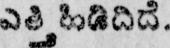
ಎತ್ತಿಹಿಡಿದಿದೆ.
